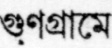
গুণগ্রামে
